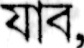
যাব,
